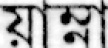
য়াম্ন
